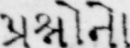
પ્રશ્નોનો
